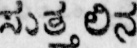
ಸುತ್ತಲಿನ
